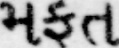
મફત
